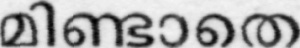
മിണ്ടാതെ
